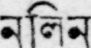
নলিন
